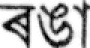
ৰঙা
